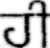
ਹੀ
